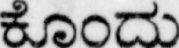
ಕೊಂದು
